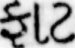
ફાટ
